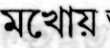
মখোয়
